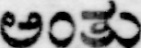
ಅಂತು
